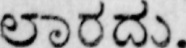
ಲಾರದು.
